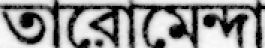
তারোমেন্দা
